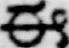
ಈ
